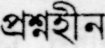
প্রশ্নহীন
